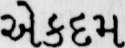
એકદમ
